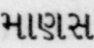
માણસ
